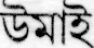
উমাই
